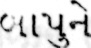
બાપુને
